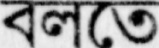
বলতে
